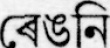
ৰেঙনি
